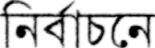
নির্বাচনে
